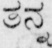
ತನ್ನ
